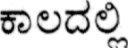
ಕಾಲದಲ್ಲಿ
